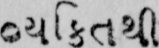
વ્યક્તિથી
